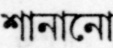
শানানো
